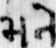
મને
